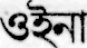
ওইনা
